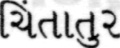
ચિંતાતુર
